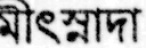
মীৎস্নাদা
